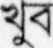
খুব
